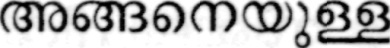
അങ്ങനെയുള്ള
